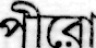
পীরো
